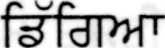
ਡਿੱਗਿਆ
